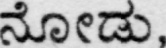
ನೋಡು,
